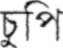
চুপি
